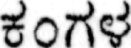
ಕಂಗಳ
